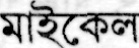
মাইকেল
